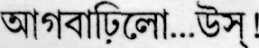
আগবাঢ়িলো...উস্!
